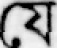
যে
